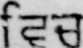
ਵਿਚ
